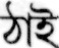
ঠাই
